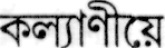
কল্যাণীয়ে
